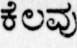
ಕೆಲವು
